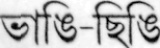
ভাঙি-ছিঙি
